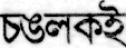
চঙলকই
